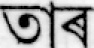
তাৰ
